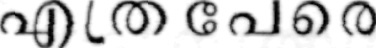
എത്രപേരെ
